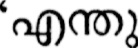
‘എന്തു
